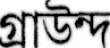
গ্রাউন্দ
